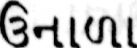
ઉનાળા
